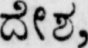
ದೇಶ,
